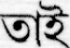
তাই
